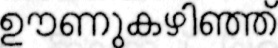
ഊണുകഴിഞ്ഞ്
